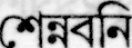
শেন্নবনি
